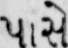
પાસે
